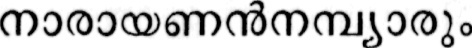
നാരായണന്‍നമ്പ്യാരും
